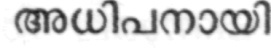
അധിപനായി
